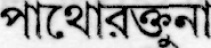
পাথোরক্তুনা
